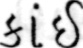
કાંઈ
